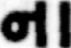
ના
